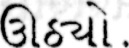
ઊઠ્યો.
